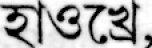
হাওখ্রে,
